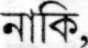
নাকি,
